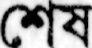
শেষ
